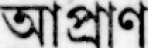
আপ্রাণ
